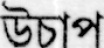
উচাপ
